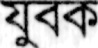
যুবক
